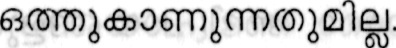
ഒത്തുകാണുന്നതുമില്ല.
